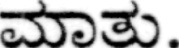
ಮಾತು.
